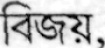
বিজয়,
